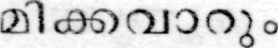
മിക്കവാറും
